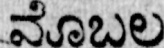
ಮೊಬಲ
